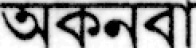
অকনবা
